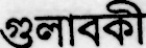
গুলাবকী
